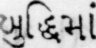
બુદ્ધિમાં
